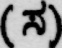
(ಸ)
